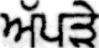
ਅੱਪੜੇ
